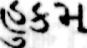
હુકમ
